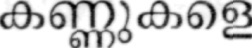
കണ്ണുകളെ
